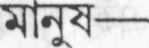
মানুষ–
